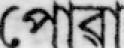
পোৱা
